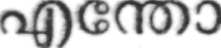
എന്തോ
